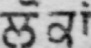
ਲੋਕਾਂ
